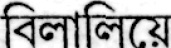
বিলালিয়ে
